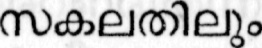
സകലതിലും
